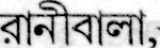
রানীবালা,
